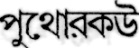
পুথোরকউ
